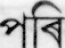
পৰি
